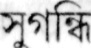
সুগন্ধি
